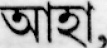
আহা,
